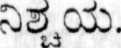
ನಿಶ್ಚಯ.
